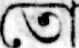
তো
